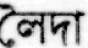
লৈদা
